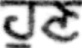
ਹੁਣ
